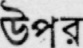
উপর
